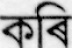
কৰি
